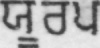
ਯੂਰਪ
